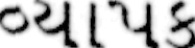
વ્યાપક
